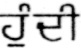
ਹੁੰਦੀ
